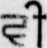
ਵੀ
